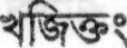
খজিক্তং
